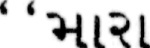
"મારા
